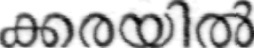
ക്കരയില്‍
